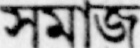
সমাজ
